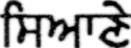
ਸਿਆਣੇ
